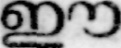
ഈ
